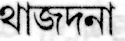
থাজদনা
